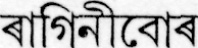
ৰাগিনীবোৰ
